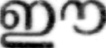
ഈ
